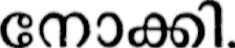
നോക്കി.
